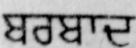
ਬਰਬਾਦ
